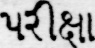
પરીક્ષા
